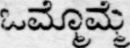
ಒಮ್ಮೊಮ್ಮೆ
